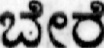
ಬೇರೆ
